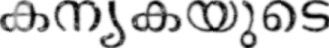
കന്യകയുടെ
